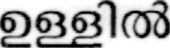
ഉള്ളില്‍
